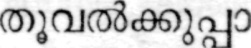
തൂവല്‍ക്കുപ്പാ
